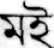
মই
